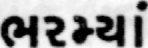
ભરમ્યાં
